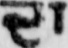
ਦਾ
